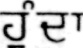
ਹੁੰਦਾ
